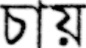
চায়
